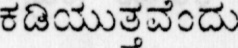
ಕಡಿಯುತ್ತವೆಂದು
